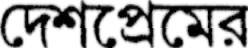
দেশপ্রেমের
